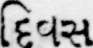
દિવસ
